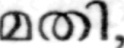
മതി,
